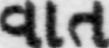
વાત
